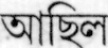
আছিল
